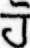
ਹੋ
